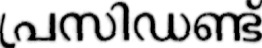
പ്രസിഡണ്ട്
